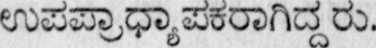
ಉಪಪ್ರಾಧ್ಯಾಪಕರಾಗಿದ್ದರು.
